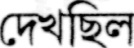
দেখছিল
